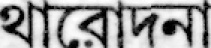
থারোদনা
